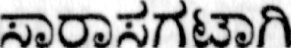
ಸಾರಾಸಗಟಾಗಿ
